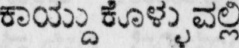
ಕಾಯ್ದುಕೊಳ್ಳುವಲ್ಲಿ
